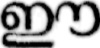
ഈ
